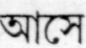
আসে
